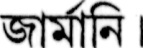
জার্মানি।
